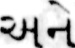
અને
